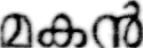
മകന്‍
